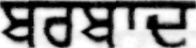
ਬਰਬਾਦ
